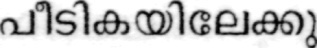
പീടികയിലേക്കു
